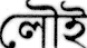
লৌই
